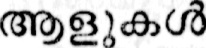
ആളുകള്‍
